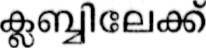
ക്ലബ്ബിലേക്ക്
